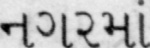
નગરમાં
